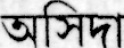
অসিদা
